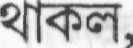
থাকল,
